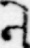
ને
